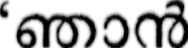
‘ഞാന്‍
